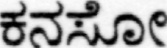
ಕನಸೋ
